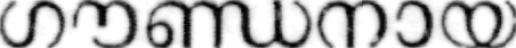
ഗൗണ്ഡനായ
